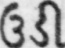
ઉડી
